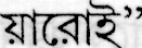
য়ারোই”
